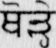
ਥੋੜ੍ਹੇ
